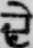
ਦੇ
